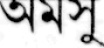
অমসু
